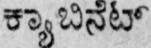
ಕ್ಯಾಬಿನೆಟ್
